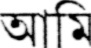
আমি
